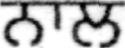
ਨਾਲ
